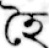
হৈ
